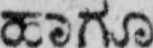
ಹಾಗೂ
